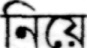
নিয়ে
